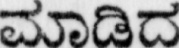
ಮಾಡಿದ
